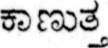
ಕಾಣುತ್ತ
